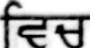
ਵਿਚ
